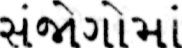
સંજોગોમાં
